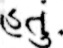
હતું.
